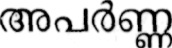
അപര്‍ണ്ണ
